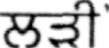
ਲੜੀ'
